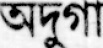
অদুগা
